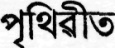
পৃথিৱীত
